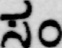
ಸಂ
